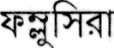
ফম্লুসিরা
